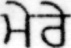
ਮੇਰੇ
